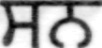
ਸਨ
